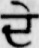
ਦੇ
